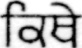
ਕਿਥੇ
